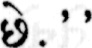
છે."
